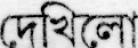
দেখিলো
